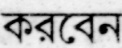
করবেন
